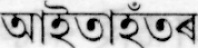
আইতাহঁতৰ
